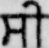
ਸੀ
